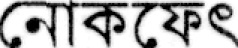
নোকফেৎ
